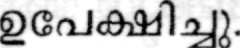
ഉപേക്ഷിച്ചു.
